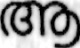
ആ
